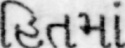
હિતમાં
